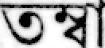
তম্বা
